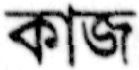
কাজ
